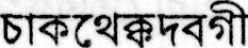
চাকথেক্কদবগী
